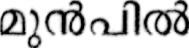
മുന്‍പില്‍
